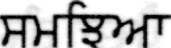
ਸਮਝਿਆ
